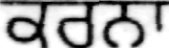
ਕਰਨਾ
